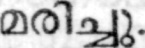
മരിച്ചു.
